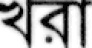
খরা
